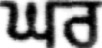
ਘਰ
